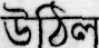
উঠিল
